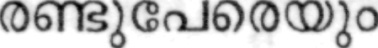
രണ്ടുപേരെയും
